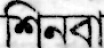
শিনবা
